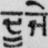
ਦੂਜੇ
